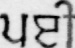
ਪਈ
